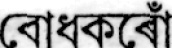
বোধকৰোঁ
